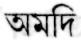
অমদি
